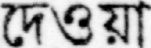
দেওয়া
